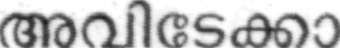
അവിടേക്കാ
